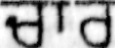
ਚਾਰ
